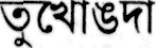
তুখোঙদা
